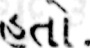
હતો.
